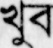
খুব
